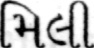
મિલી
